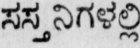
ಸಸ್ತನಿಗಳಲ್ಲಿ
